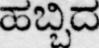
ಹಬ್ಬಿದ
